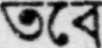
তবে
